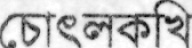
চোৎলকখি
